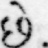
છે.
